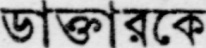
ডাক্তারকে
